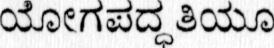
ಯೋಗಪದ್ಧತಿಯೂ
